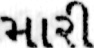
મારી
